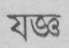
যজ্ঞ
